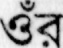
ওঁর
